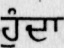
ਹੁੰਦਾ
